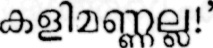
കളിമണ്ണല്ല!’
